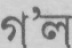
গ'ল
